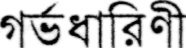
গর্ভধারিণী
